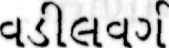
વડીલવર્ગ
